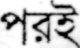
পরই
